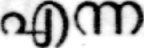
എന്ന
